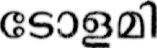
ടോളമി
